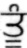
ਤੂੰ
